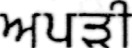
ਅਪੜੀ
